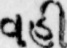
વહી
